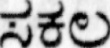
ಸಕಲ
